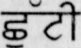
ਛੁੱਟੀ
